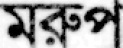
মরুপ
